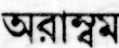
অরাম্বম
